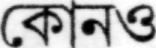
কোনও
